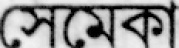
সেমেকা
